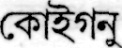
কোইগনু
